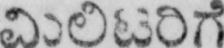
ಮಿಲಿಟರಿಗೆ
